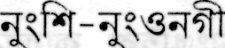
নুংশি-নুংওনগী
